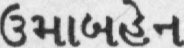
ઉમાબહેન
